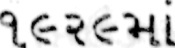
૧૯૨૯માં
